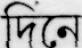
দিনে
